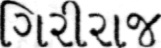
ગિરારાજ
